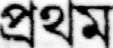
প্রথম
